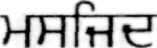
ਮਸਜਿਦ
